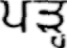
ਪੜ੍ਹ
